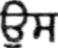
ਉਸ
